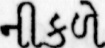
નીકળે
